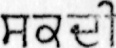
ਸਕਦੀ
